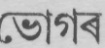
ভোগৰ
